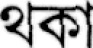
থকা
